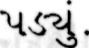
પડ્યું.
